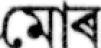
মোৰ
